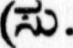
(ಸು.
